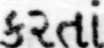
કરાતા
